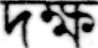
দক্ষ
